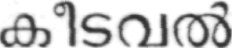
കീടവല്‍
